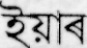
ইয়াৰ
